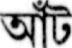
আঁট
